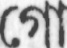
গো
